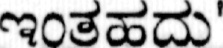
ಇಂತಹದು'
